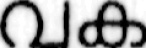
വക
